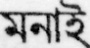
মনাই
